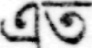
এত
